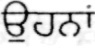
ਉਹਨਾਂ
